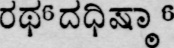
ರಥ6ದಧಿಷ್ಠಾ6
